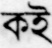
কই
